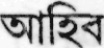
আহিব
